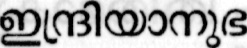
ഇന്ദ്രിയാനുഭ
